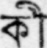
কী
